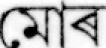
মোৰ
